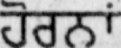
ਹੋਰਨਾਂ
